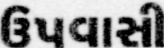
ઉપવાસી
